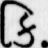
કિ.
